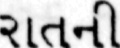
રાતની
